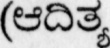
(ಆದಿತ್ಯ
